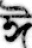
ঈ
